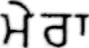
ਮੇਰਾ
